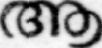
ആ
